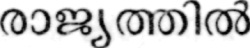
രാജ്യത്തില്‍
